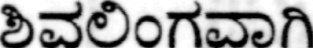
ಶಿವಲಿಂಗವಾಗಿ
